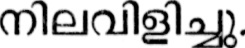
നിലവിളിച്ചു.
